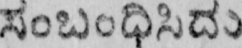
ಸಂಬಂಧಿಸಿದು
